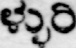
ಳ್ಳುರಿ
